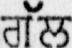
ਗੱਲ
